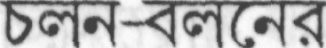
চলন-বলনের
